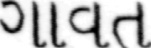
ગાવત
